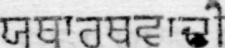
ਯਥਾਰਥਵਾਦੀ
